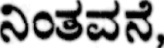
ನಿಂತವನೆ,
